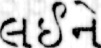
લઈને
